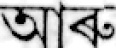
আৰু
